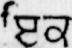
ਇਕ
